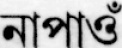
নাপাওঁ
